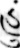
હું
